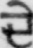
ਦੇ
